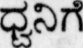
ಧ್ವನಿಗೆ
